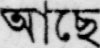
আছে
